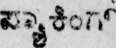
ಪ್ಯಾಕಿಂಗ್
